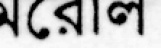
মরোল
